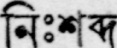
নিঃশব্দ
